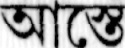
আস্তে
